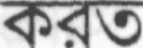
করত
